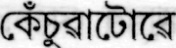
কেঁচুৱাটোৱে
